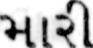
મારી
